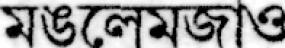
মঙলেমজাও
